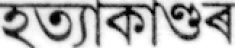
হত্যাকাণ্ডৰ
